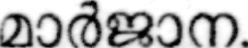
മാര്‍ജാന.
